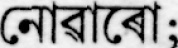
নোৱাৰো;
